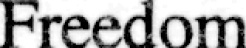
Freedom
